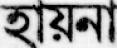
হায়না
